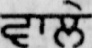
ਵਾਲੇ
